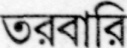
তরবারি
